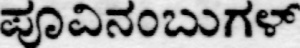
ಪೂವಿನಂಬುಗಳ್
